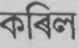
কৰিল
